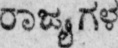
ರಾಜ್ಯಗಳ
